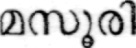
മസൂരി
